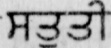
ਸਤੁਤੀ
